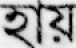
হায়
